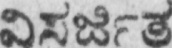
ವಿಸರ್ಜಿತ
